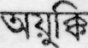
অয়ুক্কী
